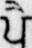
ਪੈ
